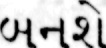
બનશે
